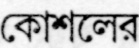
কোশলের
